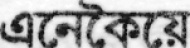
এনেকৈয়ে
